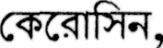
কেরোসিন,
